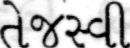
તેજસ્વી
